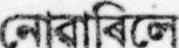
নোৱাৰিলে
